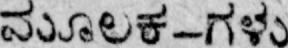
ಮೂಲಕ-ಗಳು
